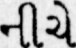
નીચે
